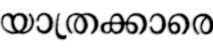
യാത്രക്കാരെ
